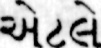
એટલે
